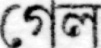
গেল
